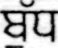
ਬੁੱਧ
